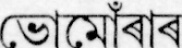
ভোমোঁৰাৰ
